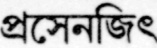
প্রসেনজিত্
